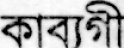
কাব্যগী
